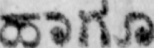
ಹಾಗೂ
